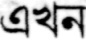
এখন
